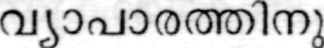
വ്യാപാരത്തിനു
